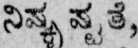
ನಿಷ್ಕೃಷ್ಟತೆ,
